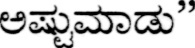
ಅಷ್ಟುಮಾಡು"
